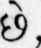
છે,
